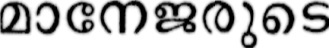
മാനേജരുടെ
